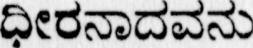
ಧೀರನಾದವನು
